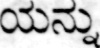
ಯನ್ನು
